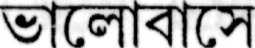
ভালোবাসে
